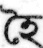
হৈ
